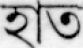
হাত
